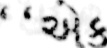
"એક
